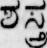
ಶಸ್ತ್ರ
